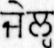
ਜੇਲ੍ਹ
